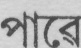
পাৱে
